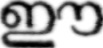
ഈ
